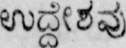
ಉದ್ದೇಶವು
